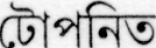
টোপনিত
